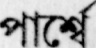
পার্শ্বে
